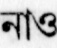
নাও
